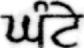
ਘੰਟੇ
